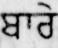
ਬਾਰੇ
